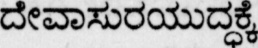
ದೇವಾಸುರಯುದ್ಧಕ್ಕೆ
